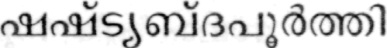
ഷഷ്ട്യബ്ദപൂര്‍ത്തി
